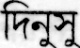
দিনুসু
